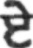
ਏ
